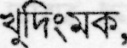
খুদিংমক,
